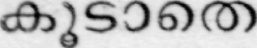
കൂടാതെ
